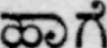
ಹಾಗೆ
